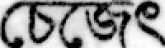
চেজেৎ
